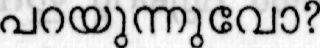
പറയുന്നുവോ?
